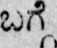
ಬಗ್ಗೆ
